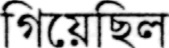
গিয়েছিল
